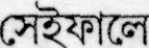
সেইফালে
